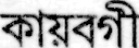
কায়বগী
